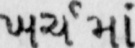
ખર્ચમાં
